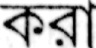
করা
